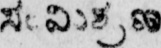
ಸಂಮಿಶ್ರಣ
